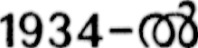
1934-ല്‍
